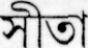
সীতা
